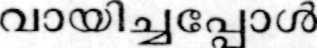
വായിച്ചപ്പോള്‍
